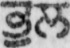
ਭੁਲ
